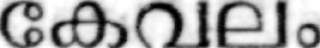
കേവലം
